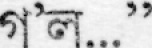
গ'ল..."
